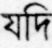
যদি
